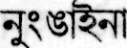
নুংঙাইনা
